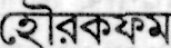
হৌরকফম
